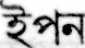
ইপন
